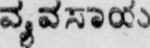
ವ್ಯವಸಾಯ
